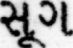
સૂગ
